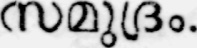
സമുദ്രം.
